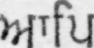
ਆਪਿ
